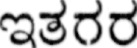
ಇತರರ
